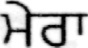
ਮੇਰਾ
